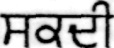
ਸਕਦੀ
